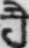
ਹੈ
